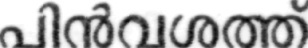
പിന്‍വശത്ത്
